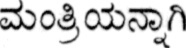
ಮಂತ್ರಿಯನ್ನಾಗಿ
